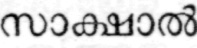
സാക്ഷാല്‍
